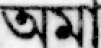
অমা
